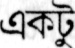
একটু
